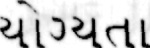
યોગ્યતા
